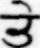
ਤੇ
